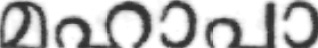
മഹാപാ
